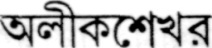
অলীকশেখর
